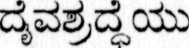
ದೈವಶ್ರದ್ಧೆಯು
